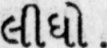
લીધો.
